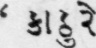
'કાઠુરે
